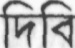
দিবি
